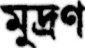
মুদ্রণ
